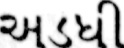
અડધી
